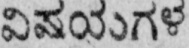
ವಿಷಯಗಳ
